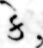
કે,
